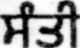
ਸੰਤੀ
